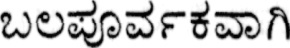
ಬಲಪೂರ್ವಕವಾಗಿ
